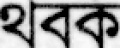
থবক
